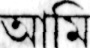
আমি
